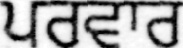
ਪਰਵਾਰ
